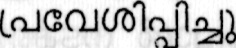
പ്രവേശിപ്പിച്ചു
